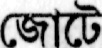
জোটে
